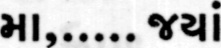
મા,............જ્યાં
